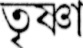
তৃষ্ণা
